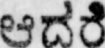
ಆದರೆ
